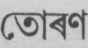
তোৰণ
